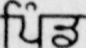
ਪਿੰਡ
